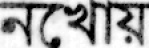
নখোয়
